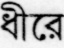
ধীরে
